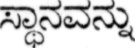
ಸ್ಥಾನವನ್ನು
